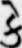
કે
